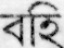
বহি
